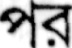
পর
